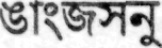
ঙাংজসনু
